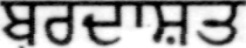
ਬਰਦਾਸ਼ਤ
